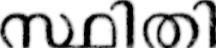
സ്ഥിതി
